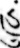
હું
